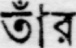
তাঁর
